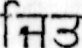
ਜਿਤ
